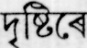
দৃষ্টিৰে
